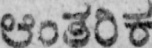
ಆಂತರಿಕ
